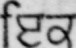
ਇਕ
